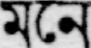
মনে
